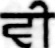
ਵੀ
